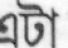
এটা
